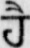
ਹੈ
